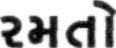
રમતો
